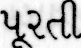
પૂરતી
